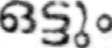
ഒട്ടും
